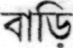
বাড়ি
